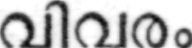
വിവരം
